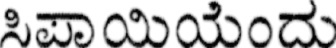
ಸಿಪಾಯಿಯೆಂದು
